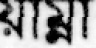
য়াম্না
